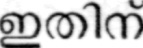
ഇതിന്
